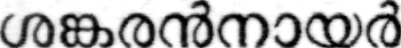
ശങ്കരന്‍നായര്‍
